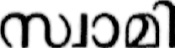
സ്വാമി
